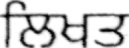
ਲਿਖਤ
